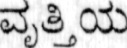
ವೃತ್ತಿಯ
